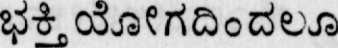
ಭಕ್ತಿಯೋಗದಿಂದಲೂ
